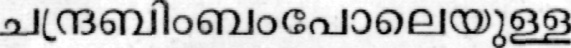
ചന്ദ്രബിംബംപോലെയുള്ള
